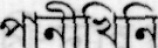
পানীখিনি
